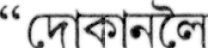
"দোকানলৈ
